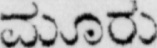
ಮೂರು
